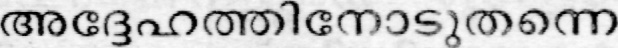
അദ്ദേഹത്തിനോടുതന്നെ
